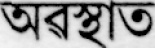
অৱস্হাত
